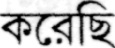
করেছি
